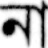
না
